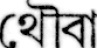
থৌবা
